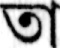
তা
